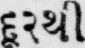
દૂરથી
